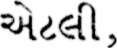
એટલી,
